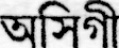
অসিগী
